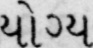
યોગ્ય
